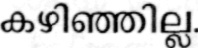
കഴിഞ്ഞില്ല.
